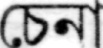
চেনা
